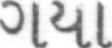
ગયા
